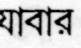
যাবার
